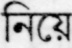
নিয়ে
